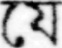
যে
